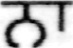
ਨਾ
